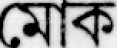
মোক
